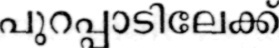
പുറപ്പാടിലേക്ക്
